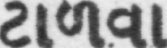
ટાળવા
